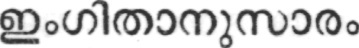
ഇംഗിതാനുസാരം
